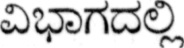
ವಿಭಾಗದಲ್ಲಿ
